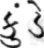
કુંડે
